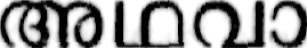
അഥവാ
